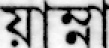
য়াম্না
